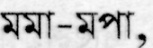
মমা-মপা,
